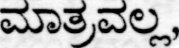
ಮಾತ್ರವಲ್ಲ,
